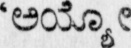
‘ಅಯ್ಯೋ
